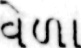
વેળા
